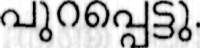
പുറപ്പെട്ടു.
